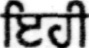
ਇਹੀ
